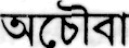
অচৌবা
